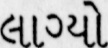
લાગ્યો
